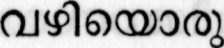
വഴിയൊരു
